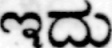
ಇದು
